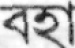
বহা
